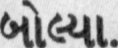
બોલ્યા.
